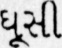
ઘૂસી
